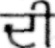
ਦੀ
